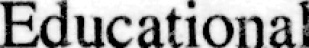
Educational
